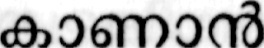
കാണാന്‍
